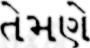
તેમણે
